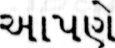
આપણે
